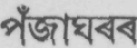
পঁজাঘৰৰ
